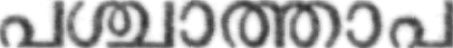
പശ്ചാത്താപ
